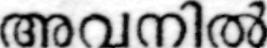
അവനില്‍
